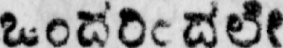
ಒಂದರಿಂದಲೇ
